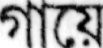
গায়ে
